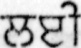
ਲਈ
